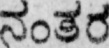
ನಂತರ
